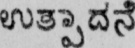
ಉತ್ಪಾದನೆ
